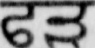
ਫੜ
